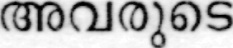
അവരുടെ
